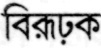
বিরূঢ়ক
